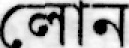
লোন
